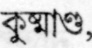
কুষ্মাণ্ড,
